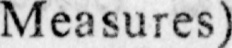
Measures)
